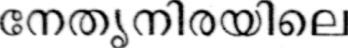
നേതൃനിരയിലെ
